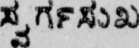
ಸ್ವರ್ಗಸುಖ
